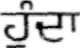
ਹੁੰਦਾ
